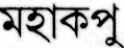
মহাকপু
